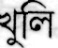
খুলি
